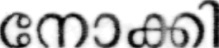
നോക്കി
